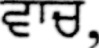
ਵਾਚ,
